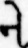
ને
